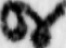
જ
